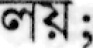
লয়;
